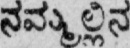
ನಮ್ಮಲ್ಲಿನ
